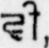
ਵੀ,
